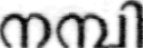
നമ്പി
